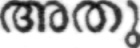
അതു
